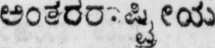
ಅಂತರರಾಷ್ಟ್ರೀಯ
